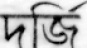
দর্জি
